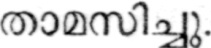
താമസിച്ചു.
